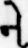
ને
